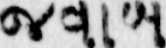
જવાબ
